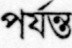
পর্যন্ত
